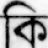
কি
